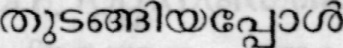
തുടങ്ങിയപ്പോള്‍
